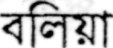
বলিয়া
